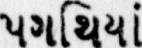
પગથિયાં
